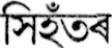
সিহঁতৰ
